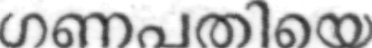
ഗണപതിയെ
